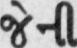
જેની
